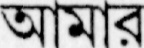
আমার
